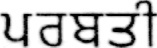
ਪਰਬਤੀ
